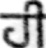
ਹੀ
